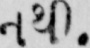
નથી.
